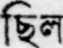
ছিল
